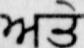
ਅਤੇ
